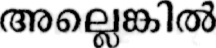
അല്ലെങ്കില്‍
